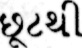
છૂટથી
